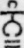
ਨੂੰ
